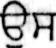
ਉਸ
